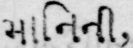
માનિની,
